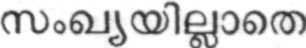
സംഖ്യയില്ലാതെ
